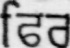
ਫਿਰ
